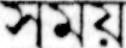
সময়
